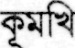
কূমখি
